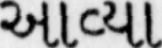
આવ્યા
